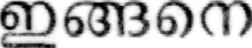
ഇങ്ങനെ
